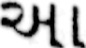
આ
